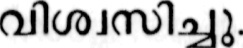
വിശ്വസിച്ചു.
